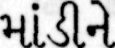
માંડીને
